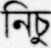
নিচু
